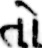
તો
